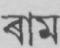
ৰাম
